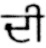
ਦੀ
